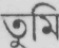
তুমি
